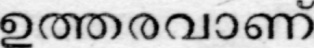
ഉത്തരവാണ്
